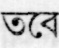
তবে
